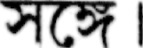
সঙ্গে।
